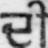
ਦੀ
